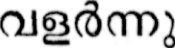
വളര്‍ന്നു
